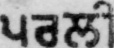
ਪਰਲੀ
